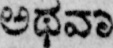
ಅಥವಾ
